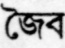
জৈব
